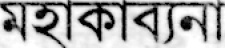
মহাকাব্যনা
